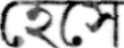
হেসে
